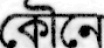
কৌনে
